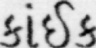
કાંઈક
